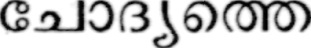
ചോദ്യത്തെ
